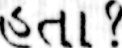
હતા?
